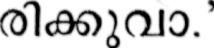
രിക്കുവാ.’
